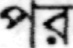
পর
